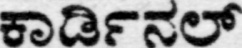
ಕಾರ್ಡಿನಲ್
